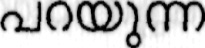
പറയുന്ന
